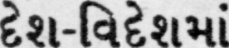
દેશ-વિદેશમાં
